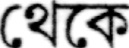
থেকে
